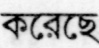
করেছে
